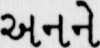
અનને
